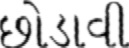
છોડાવી
